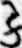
કે
